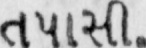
તપાસી.
